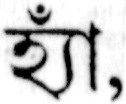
হ্যাঁ,
